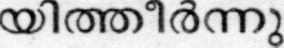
യിത്തീര്‍ന്നു
